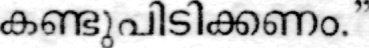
കണ്ടുപിടിക്കണം.”
